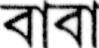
বাবা
